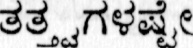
ತತ್ತ್ವಗಳಷ್ಟೇ
